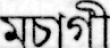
মচাগী
